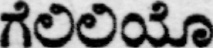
ಗೆಲಿಲಿಯೊ
